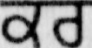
ਕਰ
